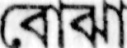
বোঝা
